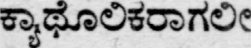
ಕ್ಯಾಥೊಲಿಕರಾಗಲೀ
